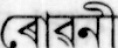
ৰোৱনী
